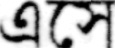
এসে
